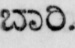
ಬಾರಿ.
